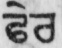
ਫੇਰ
